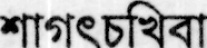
শাগৎচখিবা
